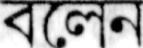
বলেন
